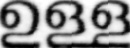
ഉള്ള
